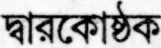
দ্বারকোষ্ঠক
